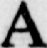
A
